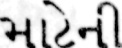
માટેની
